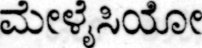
ಮೇಳೈಸಿಯೋ
